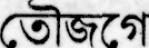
তৌজগে
